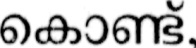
കൊണ്ട്,
